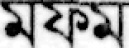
মফম
